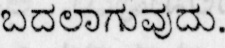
ಬದಲಾಗುವುದು.
